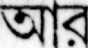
আর
